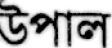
উপাল
